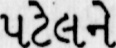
પટેલને
